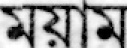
ময়াম
